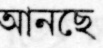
আনছে
